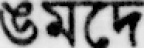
ঙমদে
